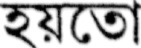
হয়তো
